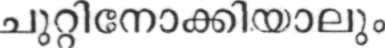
ചുറ്റിനോക്കിയാലും
